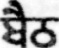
ਬੈਠ
